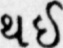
થઈ
